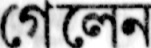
গেলেন
